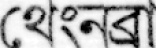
থেংনব্রা
